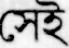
সেই
